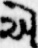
એ
